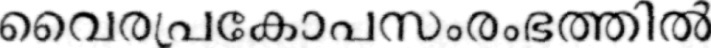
വൈരപ്രകോപസംരംഭത്തില്‍
